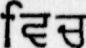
ਵਿਚ
